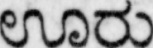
ಊರು
